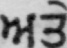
ਅਤੇ
